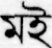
মই
